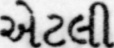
એટલી
